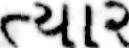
ત્યાર
